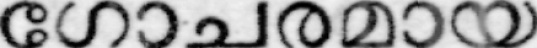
ഗോചരമായ
